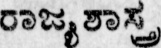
ರಾಜ್ಯಶಾಸ್ತ್ರ
